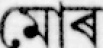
মোৰ
